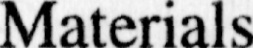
Materials
